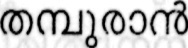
തമ്പുരാന്‍
